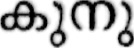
കുനു
